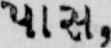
પાસ,
